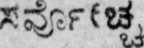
ಸರ್ವೋಚ್ಚ
